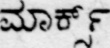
ಮಾರ್ಕ್ಸ್
